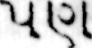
પણ
